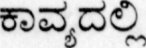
ಕಾವ್ಯದಲ್ಲಿ
